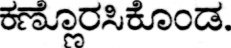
ಕಣ್ಣೊರಸಿಕೊಂಡ.
